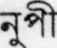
নুপী
